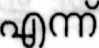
എന്ന്
